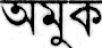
অমুক
